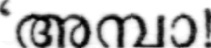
‘അമ്പാ!
